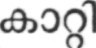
കാറ്റി
